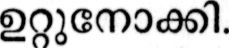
ഉറ്റുനോക്കി.
